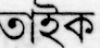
তাইক
